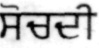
ਸੋਚਦੀ
